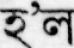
হ'ল
